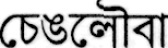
চেঙলৌবা
